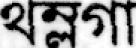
থম্লগা
